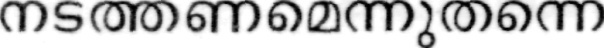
നടത്തണമെന്നുതന്നെ
